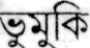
ভুমুকি
